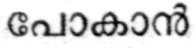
പോകാന്‍
